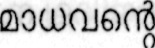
മാധവന്റെ
